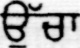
ਉੱਚਾ
